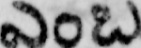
ಎಂಬ
